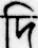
দি
